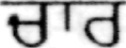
ਚਾਰ
